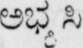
ಅಭ್ಯಸಿ
